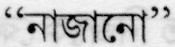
"নাজানো"
